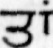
ਤਾਂ
